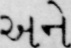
અને
